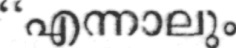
"എന്നാലും
